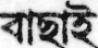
বাছাই
